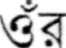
ওঁর
